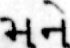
મને
